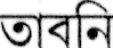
তাবনি
